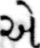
એ
